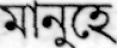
মানুহে
